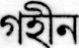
গহীন
